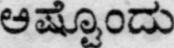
ಅಷ್ಟೊಂದು
